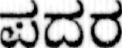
ಪದರ
